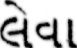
લેવા
